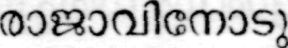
രാജാവിനോടു
